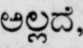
ಅಲ್ಲದೆ,
